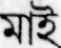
মাই
